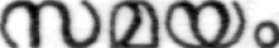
സമയം
